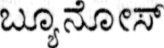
ಬ್ಯೂನೋಸ್
